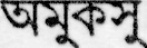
অমুকসু
